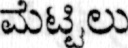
ಮೆಟ್ಟಿಲು
